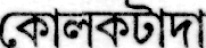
কোলকটাদা
